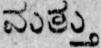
ಮತ್ತು
